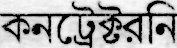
কনট্রেক্টরনি
